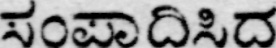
ಸಂಪಾದಿಸಿದ
